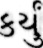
કર્યું
